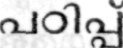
പഠിപ്പ്
